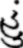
હું
